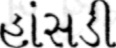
હાંસડી
